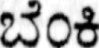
ಬೆಂಕಿ
